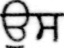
ਉਸ
